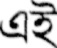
এই
